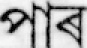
পাৰ
